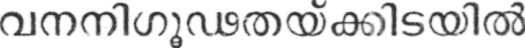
വനനിഗൂഢതയ്ക്കിടയില്‍
